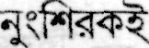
নুংশিরকই
